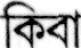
কিবা
